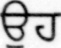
ਉਹ
